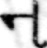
ન
